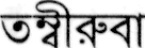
তম্বীরুবা
